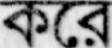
করে
